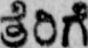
ತೆರಿಗೆ
